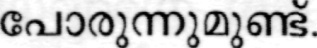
പോരുന്നുമുണ്ട്.
